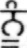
ਨੂੰ
